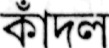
কাঁদল
